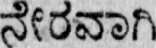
ನೇರವಾಗಿ
